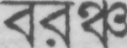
বরঞ্চ
